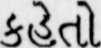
કહેતો
